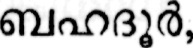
ബഹദൂര്‍,
